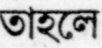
তাহলে
